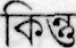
কিন্তু
